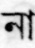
না
